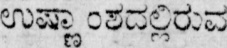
ಉಷ್ಣಾಂಶದಲ್ಲಿರುವ
